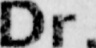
Dr.
